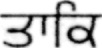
ਤਾਕਿ
